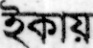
ইকায়
